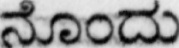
ನೊಂದು
